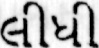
લીધી
